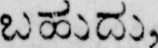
ಬಹುದು,
